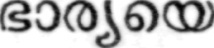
ഭാര്യയെ
